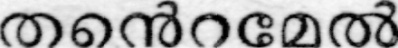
തന്റെമേല്‍
